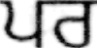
ਪਰ
